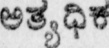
ಅತ್ಯಧಿಕ
